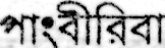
পাংবীরিবা
